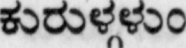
ಕುರುಳ್ಗಳುಂ
